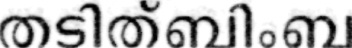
തടിത്ബിംബ
